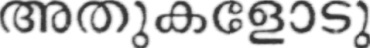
അതുകളോടു
